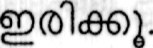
ഇരിക്കൂ.
